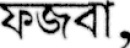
ফজবা,
